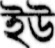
ইউ
